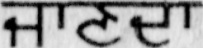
ਜਾਣਦਾ
